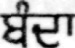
ਬੰਦਾ
